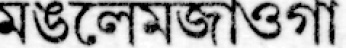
মঙলেমজাওগা
